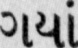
ગયાં
